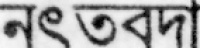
নৎতবদা
